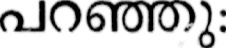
പറഞ്ഞു:
